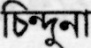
চিন্দুনা
